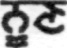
ਨੂਣ
